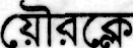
য়ৌরক্লে
